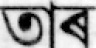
তাৰ
